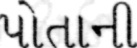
પોતાની
